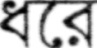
ধরে
